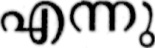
എന്നു
